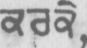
ਕਰਕੇ,
